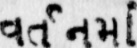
વર્તનમાં
